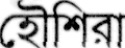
হৌশিরা
